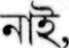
নাই,
